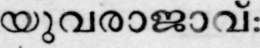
യുവരാജാവ്:
